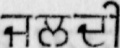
ਜਲਦੀ
